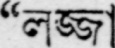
‘‘লজ্জা
